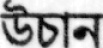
উচান
